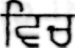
ਵਿਚ
